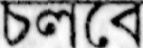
চলবে
